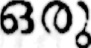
ഒരു
